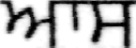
ਆਸ
